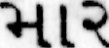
માર
